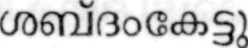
ശബ്ദംകേട്ടു
